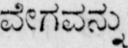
ವೇಗವನ್ನು
